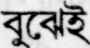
বুঝেই
